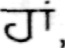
ਹਾਂ,
